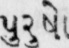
પુરુષો
